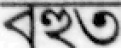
বহুত
